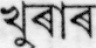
খুৰাৰ
